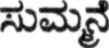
ಸುಮ್ಮನೆ
